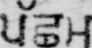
ਪੱਛਮ
